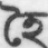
হৈ
